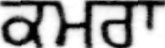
ਕਮਰਾ
